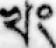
খং
